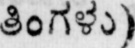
ತಿಂಗಳು)
